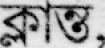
ক্লান্ত,
